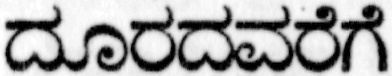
ದೂರದವರೆಗೆ
